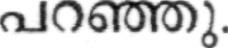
പറഞ്ഞു.
